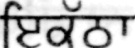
ਇਕੱਠਾ
